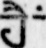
ਹੈਂ
